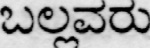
ಬಲ್ಲವರು
